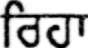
ਰਿਹਾ
